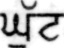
ਘੁੱਟ
